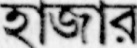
হাজার
